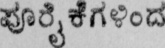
ಪೂರೈಕೆಗಳಿಂದ
